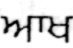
ਆਖ
